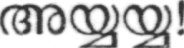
അയ്യയ്യ!
